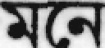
মনে
